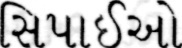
સિપાઈઓ
